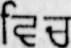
ਵਿਚ
